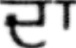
ਦਾ
